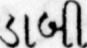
ડાબી
